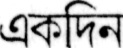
একদিন
